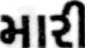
મારી
